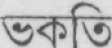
ভকতি
